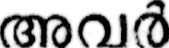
അവര്‍
